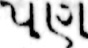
પણ
